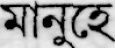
মানুহে
